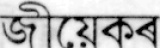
জীয়েকৰ
